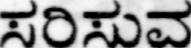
ಸರಿಸುವ
